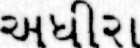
અધીરા
